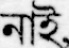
নাই,
